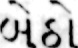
બેઠો
